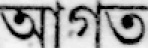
আগত
